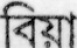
বিয়া
